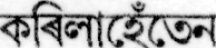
কৰিলাহেঁতেন
